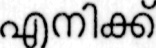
എനിക്ക്
